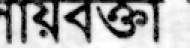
লায়বক্তা
